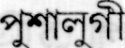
পুশালুগী
